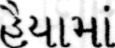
હૈયામાં
